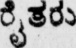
ರೈತರು
